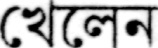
খেলেন
